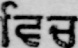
ਵਿਚ
